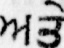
ਅਤੇ
